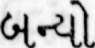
બન્યો
